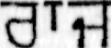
ਰਾਜ
